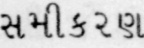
સમીકરણ
